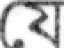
যে
